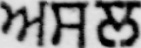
ਅਸਲ
